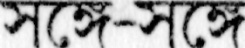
সঙ্গে-সঙ্গে
